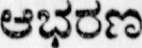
ಆಭರಣ
